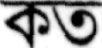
কত
